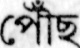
পৌঁছ
